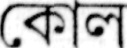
কোল
